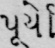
પૂર્યો
